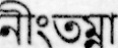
নীংতম্না
